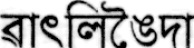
ৱাৎলিঙৈদা
